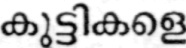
കുട്ടികളെ
